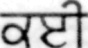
ਕਈ
